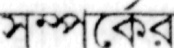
সম্পর্কের
